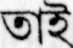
তাই
